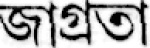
জাগ্রতা
